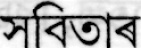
সবিতাৰ
